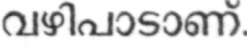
വഴിപാടാണ്.
